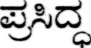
ಪ್ರಸಿದ್ಧ
